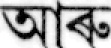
আৰু
